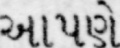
આપણે
